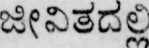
ಜೀವಿತದಲ್ಲಿ
